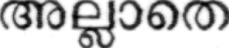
അല്ലാതെ
